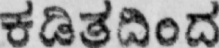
ಕಡಿತದಿಂದ
